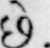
છે.
